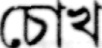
চোখ
